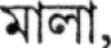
মালা,
